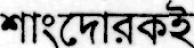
শাংদোরকই
